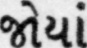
જોયાં
